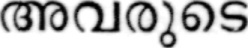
അവരുടെ
